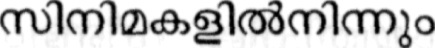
സിനിമകളില്‍നിന്നും
